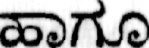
ಹಾಗೂ
